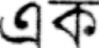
এক
